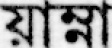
য়াম্না
